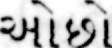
ઓછો
